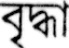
বৃদ্ধা
